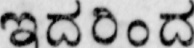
ಇದರಿಂದ
